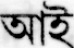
আই
